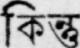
কিন্তু
